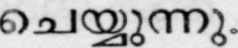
ചെയ്യുന്നു.
